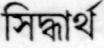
সিদ্ধার্থ
